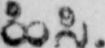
ಹಿಸಿ.
